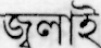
জ্বলাই
